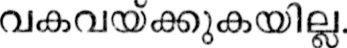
വകവയ്ക്കുകയില്ല.
